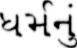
ધર્મનું
